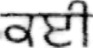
ਕਈ
